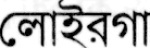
লোইরগা
